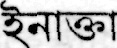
ইনাক্তা
